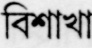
বিশাখা
